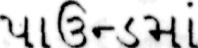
પાઉન્ડમાં
